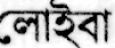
লোইবা
